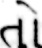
તો
